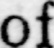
of
